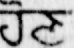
ਹੋਣ
